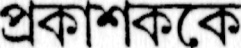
প্রকাশককে
